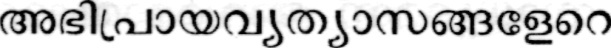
അഭിപ്രായവ്യത്യാസങ്ങളേറെ
